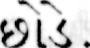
છોડે.
